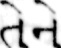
તેને
